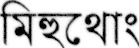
মিহুথোং
